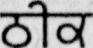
ਠੀਕ
